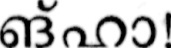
ങ്ഹാ!
